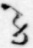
કે
